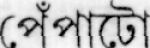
পেঁপাটো
